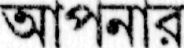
আপনার
